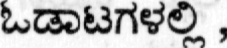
ಓಡಾಟಗಳಲ್ಲಿ,
